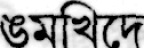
ঙমখিদে
